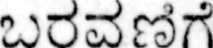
ಬರವಣಿಗೆ
